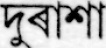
দুৰাশা
